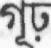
গূঢ়
